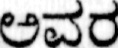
ಅವರ
